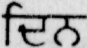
ਦਿਨ
